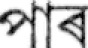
পাৰ
